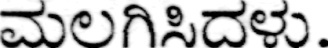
ಮಲಗಿಸಿದಳು.
